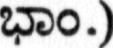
ಭಾಂ.)
